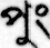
পুং
